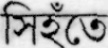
সিহঁতে
